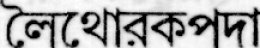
লৈথোরকপদা
